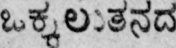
ಒಕ್ಕಲುತನದ
